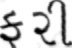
ફરી
